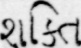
શક્તિ
